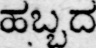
ಹಬ್ಬದ
